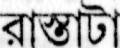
রাস্তাটা
